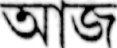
আজ
